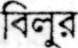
বিলুর
